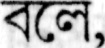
বলে,
